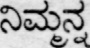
ನಿಮ್ಮನ್ನ
